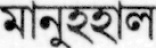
মানুহহাল
